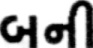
બની
